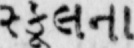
સ્કૂલના
